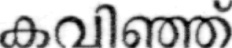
കവിഞ്ഞ്
